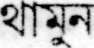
থামুন
